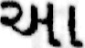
આ
